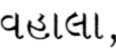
વહાલા,
